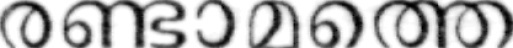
രണ്ടാമത്തെ
